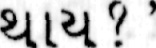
થાય?'
